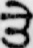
ਤੇ
